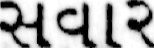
સવાર
